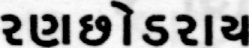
રણછોડરાય
